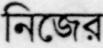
নিজের
